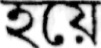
হয়ে
